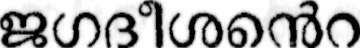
ജഗദീശന്റെ
